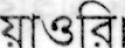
য়াওরি।
